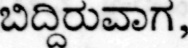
ಬಿದ್ದಿರುವಾಗ,
